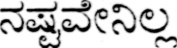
ನಷ್ಟವೇನಿಲ್ಲ
